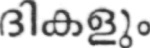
ദികളും
